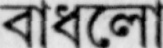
বাধলো
